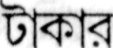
টাকার
